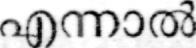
എന്നാല്‍
